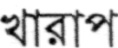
খারাপ
